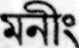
মনীং
